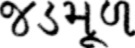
જડમૂળ
